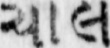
ચાલ
